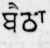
ਬੈਠਾ
